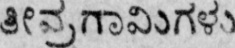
ತೀವ್ರಗಾಮಿಗಳು
